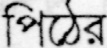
পিঠের
